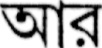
আর
